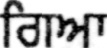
ਗਿਆ
